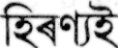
হিৰণ্যই
